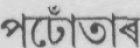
পঢোঁতাৰ
